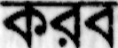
করব
